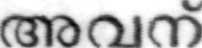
അവന്
